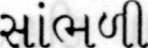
સાંભળી
